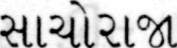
સાચોરાજા
